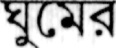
ঘুমের
